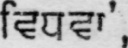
ਵਿਧਵਾ',
